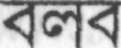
বলব
